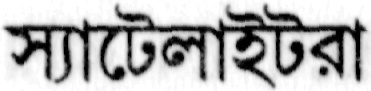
স্যাটেলাইটরা
